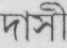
দাসী
